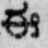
ಈ
